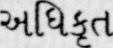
અધિકૃત
